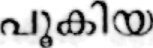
പൂകിയ
